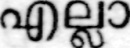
എല്ലാ
